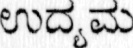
ಉದ್ಯಮ
